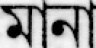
মানা
